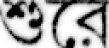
শুরে
